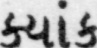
ક્યાંક
